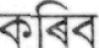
কৰিব
